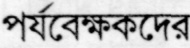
পর্যবেক্ষকদের
